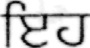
ਇਹ
